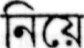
নিয়ে
